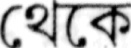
থেকে
